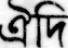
ঐদি
